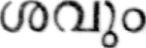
ശവും
